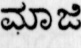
ಮಾಜಿ
